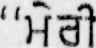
''ਮੇਰੀ
